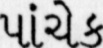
પાંચેક
